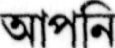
আপনি
